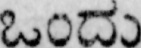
ಒಂದು
